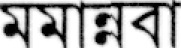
মমান্নবা
